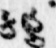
કહું
